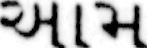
આમ
